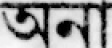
অনা
